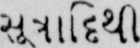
સૂત્રાદિથી
